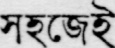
সহজেই
